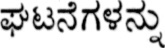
ಘಟನೆಗಳನ್ನು
